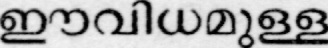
ഈവിധമുള്ള
